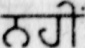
ਨਹੀਂ
